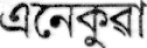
এনেকুৱা
